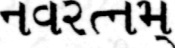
નવરત્નમ્
